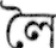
লৈ
